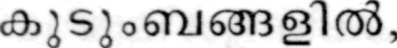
കുടുംബങ്ങളില്‍,
